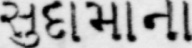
સુદામાના
